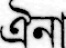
ঐনা
